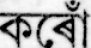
কৰোঁ
